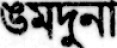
ঙমদুনা
